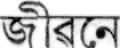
জীৱনে
